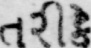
તરીકે
